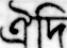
ঐদি
